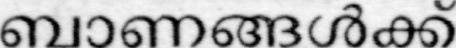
ബാണങ്ങള്‍ക്ക്
